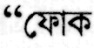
“ফোক
